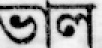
ভাল
